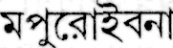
মপুরোইবনা
